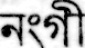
নংগী
